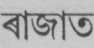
ৰাজাত
